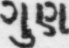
ગુણ
